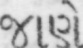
જાણે
